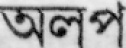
অলপ
